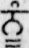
ਨੂੰ
